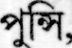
পুন্সি,
